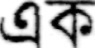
এক
